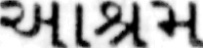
આશ્રમ
